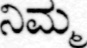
ನಿಮ್ಮ
